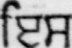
ਇਸ
